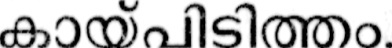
കായ്പിടിത്തം.
